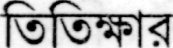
তিতিক্ষার
